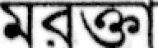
মরক্তা
